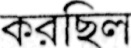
করছিল
